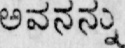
ಅವನನ್ನು
